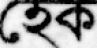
হেক
